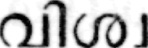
വിശ്വ
